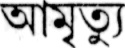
আমৃত্যু
